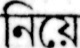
নিয়ে
